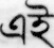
এই
